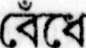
বেঁধে
